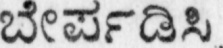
ಬೇರ್ಪಡಿಸಿ
